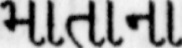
માતાના
